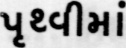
પૃથ્વીમાં
